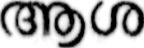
ആശ
